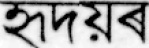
হৃদয়ৰ
